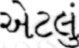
એટલું
